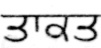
ਤਾਕਤ
